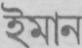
ইমান
